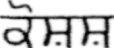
ਕੋਸ਼ਸ਼
